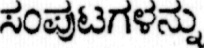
ಸಂಪುಟಗಳನ್ನು
